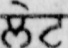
ਲੇਟ
